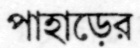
পাহাড়ের
